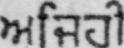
ਅਜਿਹੀ
